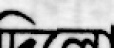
দিলো
